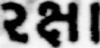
રક્ષા
